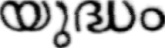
യുദ്ധം
